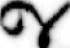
જ
